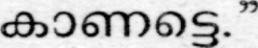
കാണട്ടെ."
